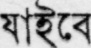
যাইবে
